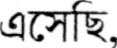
এসেছি,
